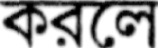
করলে
